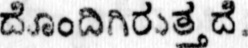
ದೊಂದಿಗಿರುತ್ತದೆ.
